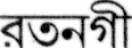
রতনগী
